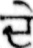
ਦੇ
